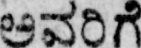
ಅವರಿಗೆ
